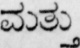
ಮತ್ತು
